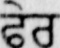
ਫੇਰ
